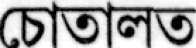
চোতালত
